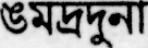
ঙমদ্রদুনা
